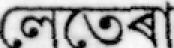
লেতেৰা
